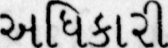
અધિકારી
